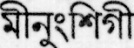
মীনুংশিগী
